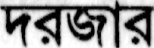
দরজার
